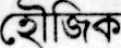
হৌজিক
